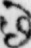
છે
